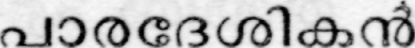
പാരദേശികന്‍
